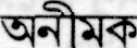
অনীমক
